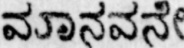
ಮಾನವನೇ
